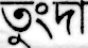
তুংদা
